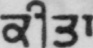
ਕੀਤਾ
